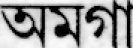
অমগা
